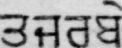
ਤਜਰਬੇ
